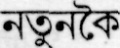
নতুনকৈ
